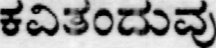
ಕವಿತಂದುವು
